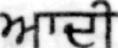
ਆਦੀ
